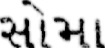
સોમા
